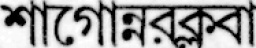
শাগোন্নরক্লবা
